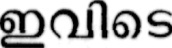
ഇവിടെ
